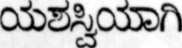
ಯಶಸ್ವಿಯಾಗಿ
